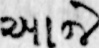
આજે
